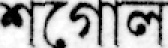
শগোল
